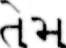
તેમ
